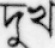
দুখ
